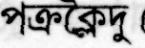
পেত্রুক্লৈদু
